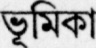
ভূমিকা
